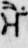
ਮੈਂ
